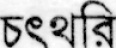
চৎথরি
